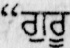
''ਗੁਰੂ
